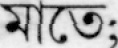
মাতে;
